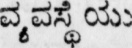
ವ್ಯವಸ್ಥೆಯು
